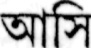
আসি
